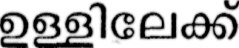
ഉള്ളിലേക്ക്
